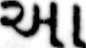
આ
